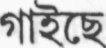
গাইছে
